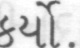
કર્યો.
